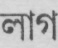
লাগ
